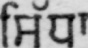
ਸਿੱਧਾ
